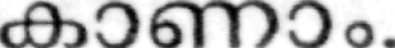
കാണാം.
